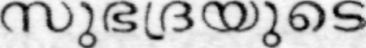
സുഭദ്രയുടെ
